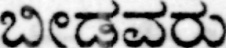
ಬೀಡವರು
